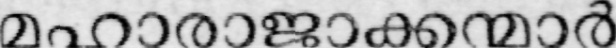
മഹാരാജാക്കന്മാര്‍
